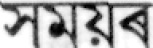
সময়ৰ
